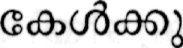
കേള്‍ക്കു
